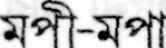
মপী-মপা
